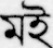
মই
